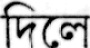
দিলে
